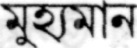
মুহ্যমান
